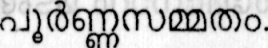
പൂര്‍ണ്ണസമ്മതം.
